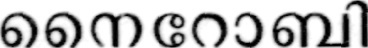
നൈറോബി
